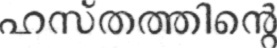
ഹസ്തത്തിന്റെ
